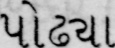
પોઢ્યા
